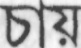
চায়
